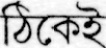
ঠিকেই
